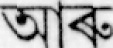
আৰু
